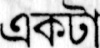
একটা
